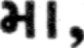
મા,
